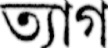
ত্যাগ
